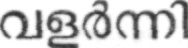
വളര്‍ന്നി
